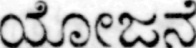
ಯೋಜನೆ
